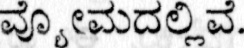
ವ್ಯೋಮದಲ್ಲಿವೆ.
